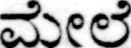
ಮೇಲೆ
